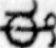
ಈ
